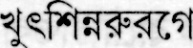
খুৎশিন্নরুরগে
